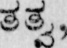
ತತ್ವ,
